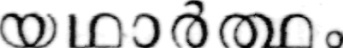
യഥാര്‍ത്ഥം
